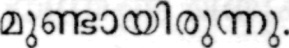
മുണ്ടായിരുന്നു.
